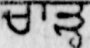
ਚਾੜ੍ਹ
